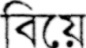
বিয়ে
